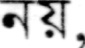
নয়,
